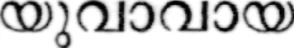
യുവാവായ
